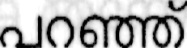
പറഞ്ഞ്
